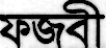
ফজবী
